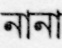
নানা
